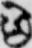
છે
